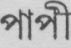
পাপী
